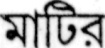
মাটির
